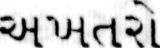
અખતરો
